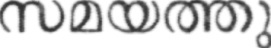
സമയത്തു
